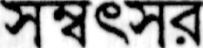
সম্বৎসর
